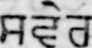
ਸਵੇਰ
